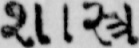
શાસ્ત્ર
